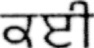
ਕਈ
